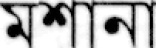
মশানা
